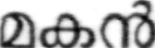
മകന്‍
